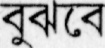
বুঝবে
